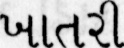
ખાતરી
